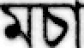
মচা
